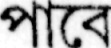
পাবে
